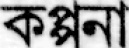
কপ্পনা
